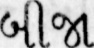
બીજા
